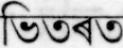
ভিতৰত
